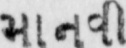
માનવી
